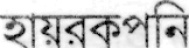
হায়রকপনি
